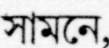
সামনে,
